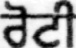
ਰੋਟੀ
